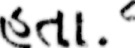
હતા.૮
